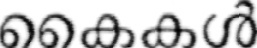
കൈകള്‍
